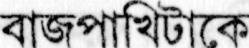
বাজপাখিটাকে
